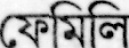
ফেমিলি
